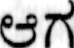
ಆಗ
